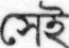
সেই
